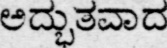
ಅದ್ಭುತವಾದ
